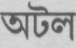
অটল
